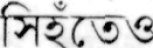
সিহঁতেও
